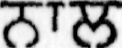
ਨਾਲ
